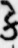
કે
